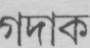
গদাক
